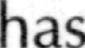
has
